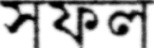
সফল
